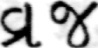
વ્રજ
